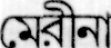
মেরীনা
